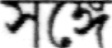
সঙ্গে
